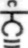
ਨੂੰ
